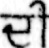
ਦੀ
